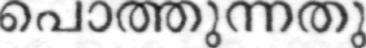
പൊത്തുന്നതു
